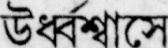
উর্ধ্বশ্বাসে
